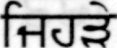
ਜਿਹੜੇ
